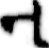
ન
